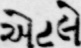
એટલે
